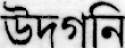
উদগনি
